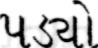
પડ્યો
